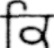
ਕਿ
